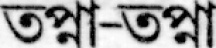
তপ্না-তপ্না
